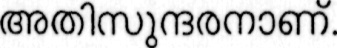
അതിസുന്ദരനാണ്.
